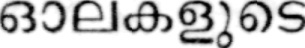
ഓലകളുടെ
